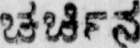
ಚರ್ಚಿನ
